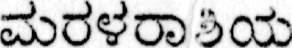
ಮರಳರಾಶಿಯ
